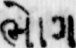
ભોગ
